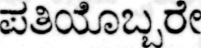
ಪತಿಯೊಬ್ಬರೇ
